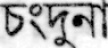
চংদুনা
